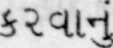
કરવાનું
